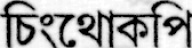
চিংথোকপি
